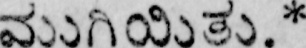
ಮುಗಿಯಿತು.*
